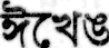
ঈখেঙ
